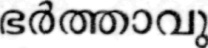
ഭര്‍ത്താവു
